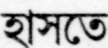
হাসতে
